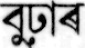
বুঢ়াৰ
